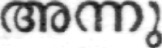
അന്നു
